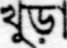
খুড়া
